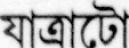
যাত্রাটো
